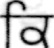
ਕਿ
